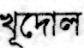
খূদোল
